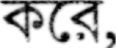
করে,
